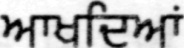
ਆਖਦਿਆਂ
